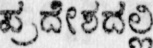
ಪ್ರದೇಶದಲ್ಲಿ
